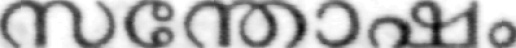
സന്തോഷം
